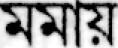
মমায়
